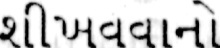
શીખવવાનો
